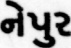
નેપુર
